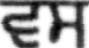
ਵਸ
